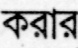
করার
